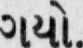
ગયો.
